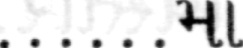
......મા
